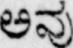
ಅವು
